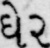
ઘેર
